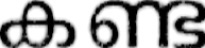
കണ്ട
